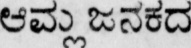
ಆಮ್ಲಜನಕದ
